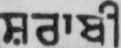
ਸ਼ਰਾਬੀ
